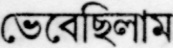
ভেবেছিলাম
